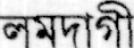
লমদাগী
